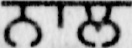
ਨਾਲ
